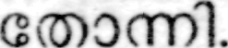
തോന്നി.
